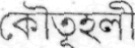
কৌতূহলী
